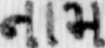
નામ
